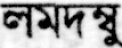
লমদম্বু
